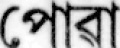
পোৱা
